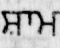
ਸ਼ਾਮ
